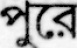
পুরে
